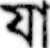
যা
